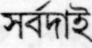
সর্বদাই
